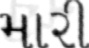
મારી
